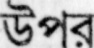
উপর
